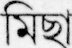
মিছা
